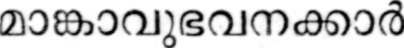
മാങ്കാവുഭവനക്കാര്‍
